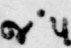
જંપ
